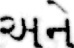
અને
